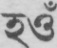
হওঁ
